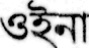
ওইনা
